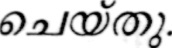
ചെയ്തു.
